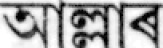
আল্লাৰ
